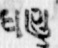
ઘણું
